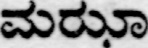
ಮಝಾ
